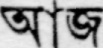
আজ
